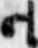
ન
